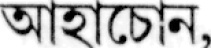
আহাচোন,
